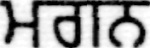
ਮਗਨ
